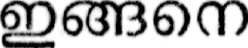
ഇങ്ങനെ
